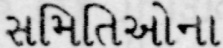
સમિતિઓના
